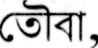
তৌবা,
